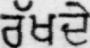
ਰੱਖਦੇ
